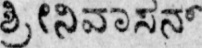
ಶ್ರೀನಿವಾಸನ್
